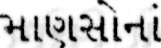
માણસોનાં
